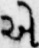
એ
